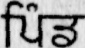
ਪਿੰਡ
